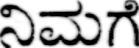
ನಿಮಗೆ
